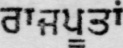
ਰਾਜਪੂਤਾਂ
